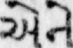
એને
